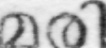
മരി
